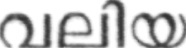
വലിയ
